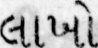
લાખો
